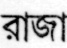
রাজা
